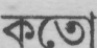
কতো
